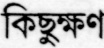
কিছুক্ষণ
